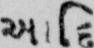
આદિ
